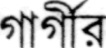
গার্গীর
